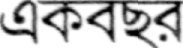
একবছর
